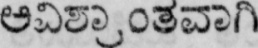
ಅವಿಶ್ರಾಂತವಾಗಿ
